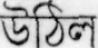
উঠিল
